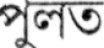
পুলত
